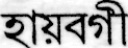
হায়বগী
